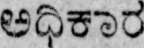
ಅಧಿಕಾರ
